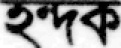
হন্দক
